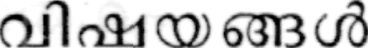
വിഷയങ്ങള്‍
